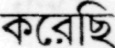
করেছি
